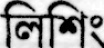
লিশিং
